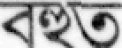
বহুত
